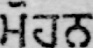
ਮੋਹਨ
